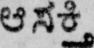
ಆಸಕ್ತಿ
